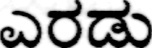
ಎರಡು
